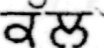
ਕੱਲ
